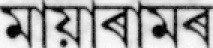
মায়াৰামৰ
